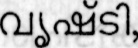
വൃഷ്ടി,
